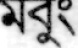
মবুং
